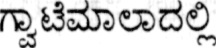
ಗ್ವಾಟೆಮಾಲಾದಲ್ಲಿ
